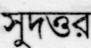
সুদত্তর
